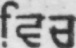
ਵਿਚ
